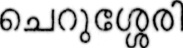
ചെറുശ്ശേരി
